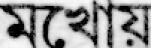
মখোয়
